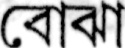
বোঝা
